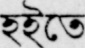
হইতে
